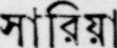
সারিয়া
